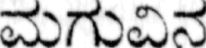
ಮಗುವಿನ
